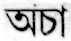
অচা
